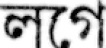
লগে
